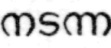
നടന്ന
